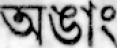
অঙাং
